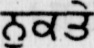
ਨੁਕਤੇ
